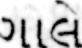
ગાલે
